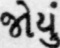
જોયું
